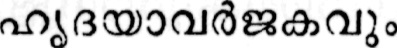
ഹൃദയാവര്‍ജകവും
